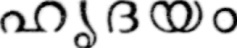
ഹൃദയം
